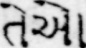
તેઓ
